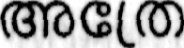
അത്രേ
